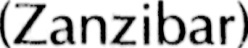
(Zanzibar)
